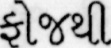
ફોજથી
